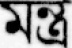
মন্ত্র
